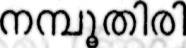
നമ്പൂതിരി
